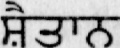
ਸ਼ੈਤਾਨ
